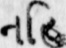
નહિ
